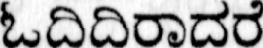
ಓದಿದಿರಾದರೆ
